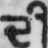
ਦੀ
